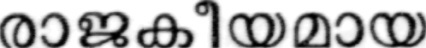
രാജകീയമായ
